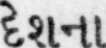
દેશના
